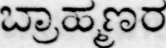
ಬ್ರಾಹ್ಮಣರ
